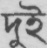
দুই
